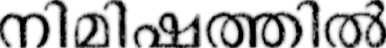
നിമിഷത്തില്‍
